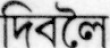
দিবলৈ
